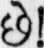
છે!
